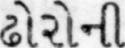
ઢોરની
